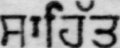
ਸਾਹਿੱਤ
